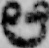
ಆ
